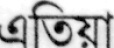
এতিয়া
